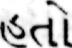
હતો
